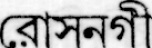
রোসনগী
